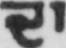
ਦਾ
